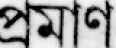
প্রমাণ
